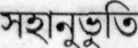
সহানুভুতি
